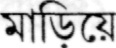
মাড়িয়ে
